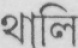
থালি
